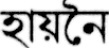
হায়নৈ
